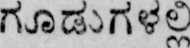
ಗೂಡುಗಳಲ್ಲಿ
